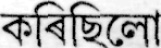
কৰিছিলো
